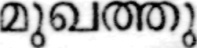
മുഖത്തു
